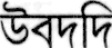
উবদদি
